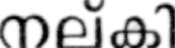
നല്കി
